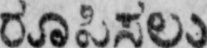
ರೂಪಿಸಲು
